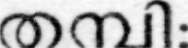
തമ്പി:
